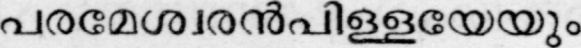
പരമേശ്വരന്‍പിള്ളയേയും
